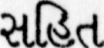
સહિત
